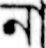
না
